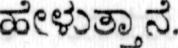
ಹೇಳುತ್ತಾನೆ.
